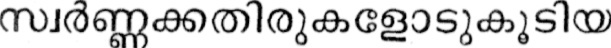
സ്വര്‍ണ്ണക്കതിരുകളോടുകൂടിയ
